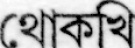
থোকখি
